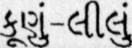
કૂણું-લીલું
